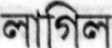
লাগিল
